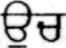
ਉਚ
